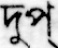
দুপ্
